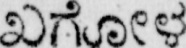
ಖಗೋಳ
